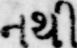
નથી
